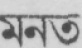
মনত
